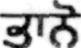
ਭਾਨੋ
